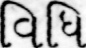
વિધિ
